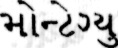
મોન્ટેગ્યુ
